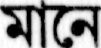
মানে
